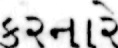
કરનારે
